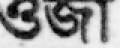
ওজা
